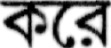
করে
